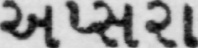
અપ્સરા
